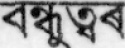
বন্ধুত্বৰ
